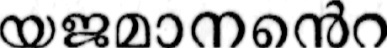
യജമാനന്റെ
